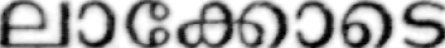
ലാക്കോടെ
